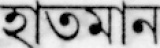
হাতমান
